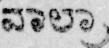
ವಾಲ್ರಾ
